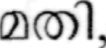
മതി,
